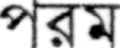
পরম
